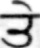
ਤੇ
